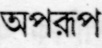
অপরূপ
